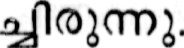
ച്ചിരുന്നു.
